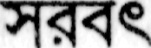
সরবৎ
